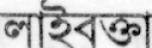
লাইবক্তা
